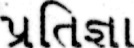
પ્રતિજ્ઞા
